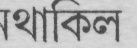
নথাকিল
